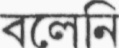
বলেনি
